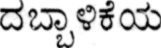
ದಬ್ಬಾಳಿಕೆಯ
